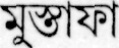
মুস্তাফা
